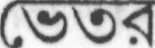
ভেতর
